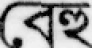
বেহু
